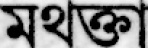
মথক্তা
